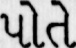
પોતે
